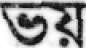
ভয়
